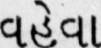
વહેવા
